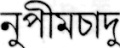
নুপীমচাদু
